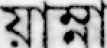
য়াম্না
